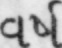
વર્ષ
